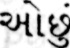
ઓછું
